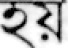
হয়
